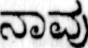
ನಾವು
